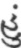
હું
